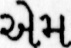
એમ
